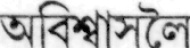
অবিশ্বাসলৈ
